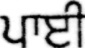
ਪਾਈ
